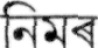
নিমৰ
